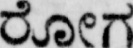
ರೋಗ
